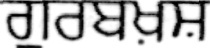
ਗੁਰਬਖ਼ਸ਼
